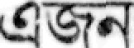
এজন
